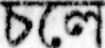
চলে
